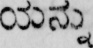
ಯನ್ನು
